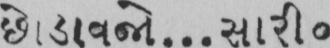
છોડાવજો...સારી.
